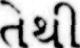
તેથી
